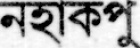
নহাকপু
